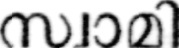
സ്വാമി
